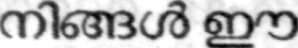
നിങ്ങള്‍ഈ
